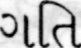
ગતિ
